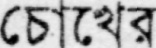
চোখের
